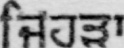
ਜਿਹੜਾ
